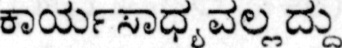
ಕಾರ್ಯಸಾಧ್ಯವಲ್ಲದ್ದು
